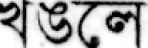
খঙলে
